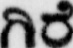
ಗಿರೆ
